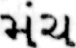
મંચ
